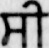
ਸੀ
